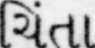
ચિંતા
